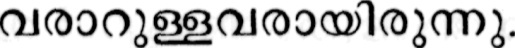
വരാറുള്ളവരായിരുന്നു.
